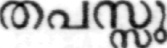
തപസ്സു
